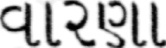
વારણા
